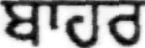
ਬਾਹਰ
